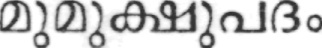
മുമുക്ഷുപദം
